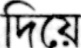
দিয়ে
